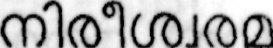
നിരീശ്വരമ
